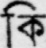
কি
